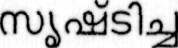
സൃഷ്ടിച്ച
